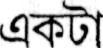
একটা
